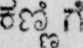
ಕಣ್ಣಿಗೆ
